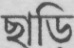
ছাড়ি
